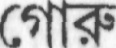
গোরু
